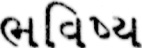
ભવિષ્ય
